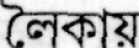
লৈকায়
